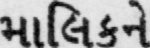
માલિકને
